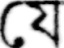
যে
